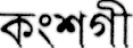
কংশগী
